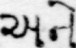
અને
